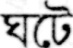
ঘটে
